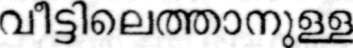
വീട്ടിലെത്താനുള്ള
